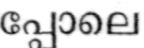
പ്പോലെ
